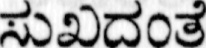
ಸುಖದಂತೆ
